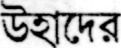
উহাদের
